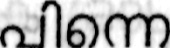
പിന്നെ
